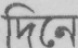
দিনে
